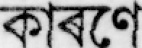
কাৰণে
